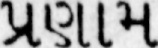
પ્રણામ
